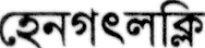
হেনগৎলক্লি
